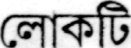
লোকটি
